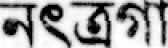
নৎত্রগা
